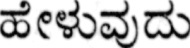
ಹೇಳುವುದು
